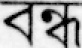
বন্ধ
